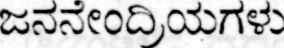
ಜನನೇಂದ್ರಿಯಗಳು
